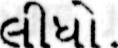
લીધો.
